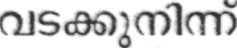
വടക്കുനിന്ന്
